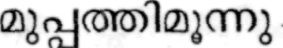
മുപ്പത്തിമൂന്നു.
